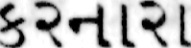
કરનારા
